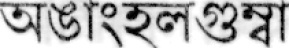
অঙাংহলগুম্বা
